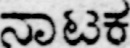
ನಾಟಕ
